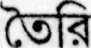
তৈরি
